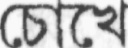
চোখে
